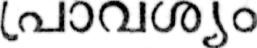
പ്രാവശ്യം
